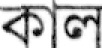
কাল
